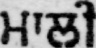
ਮਾਲੀ
